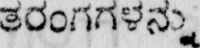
ತರಂಗಗಳನ್ನು
